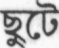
ছুটে
